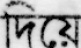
দিয়ে
